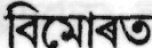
বিমোৰত
